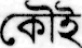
কৌই
